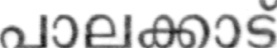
പാലക്കാട്
